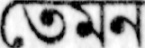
তেমন
